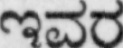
ಇವರ
